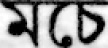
মচে
